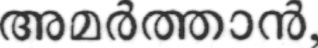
അമര്‍ത്താന്‍,
